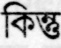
কিন্তু
